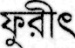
ফুরীৎ
